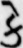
કે
